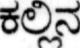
ಕಲ್ಲಿನ
